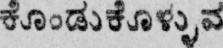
ಕೊಂಡುಕೊಳ್ಳುವ
